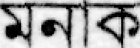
মনাক
